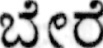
ಬೇರೆ
